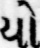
યો
